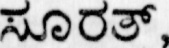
ಸೂರತ್,
